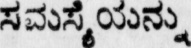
ಸಮಸ್ಯೆಯನ್ನು
